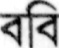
ববি
